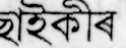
ছাইকীৰ
